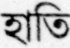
হাতি
